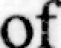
of
